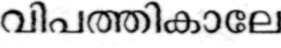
വിപത്തികാലേ
